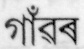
গাঁৱৰ
